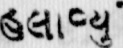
હલાવ્યું
